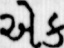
એક
